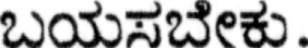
ಬಯಸಬೇಕು.
